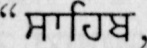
''ਸਾਹਿਬ,
